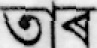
তাৰ
